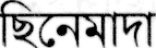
ছিনেমাদা
